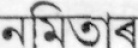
নমিতাৰ
